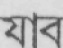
যাব
